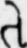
તે
